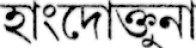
হাংদোক্তুনা
